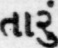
તારું
